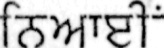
ਨਿਆਈਂ
